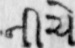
નીચે
